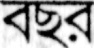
বছর
